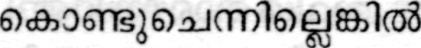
കൊണ്ടുചെന്നില്ലെങ്കില്‍
